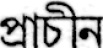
প্রাচীন
